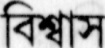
বিশ্বাস
